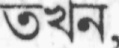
তখন,
